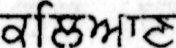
ਕਲਿਆਣ
